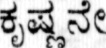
ಕೃಷ್ಣನೇ
